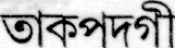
তাকপদগী
